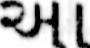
આ
